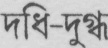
দধি-দুগ্ধ
